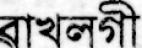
ৱাখলগী
